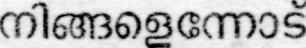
നിങ്ങളെന്നോട്
